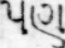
પણ
